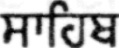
ਸਾਹਿਬ
